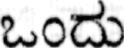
ಒಂದು
